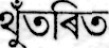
থুঁতৰিত
